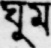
ঘুম
